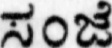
ಸಂಜೆ
